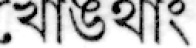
খোঙথাং
